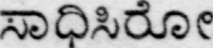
ಸಾಧಿಸಿರೋ
